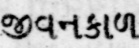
જીવનકાળ
